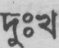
দুঃখ
